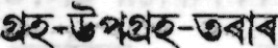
গ্ৰহ-উপগ্ৰহ-তৰাৰ
